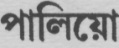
পালিয়ো
